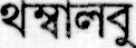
থম্বালবু
